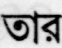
তার
